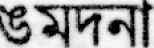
ঙমদনা
